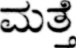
ಮತ್ತೆ
